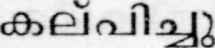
കല്പിച്ചു
